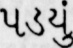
પડયું
